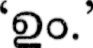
‘ഉം.'
